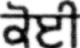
ਕੋਈ
